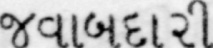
જવાબદારી
